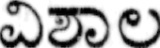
ವಿಶಾಲ
